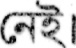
নেই।
